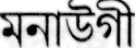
মনাউগী
